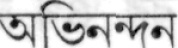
অভিনন্দন
